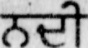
ਨਦੀ
